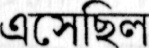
এসেছিল
